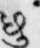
છું
